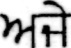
ਅਜੇ
